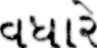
વધારે
